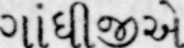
ગાંધીજીએ
